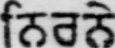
ਨਿਰਨੇ
